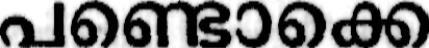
പണ്ടൊക്കെ
